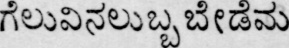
ಗೆಲುವಿನಲುಬ್ಬಬೇಡೆಮ
